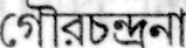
গৌরচন্দ্রনা
